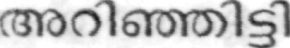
അറിഞ്ഞിട്ടി
